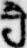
ਹੈ
